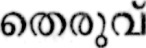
തെരുവ്
